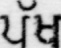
ਪੱਖ
